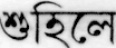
শুহিলে
